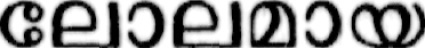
ലോലമായ
